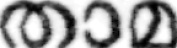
താമ
